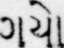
ગયો
